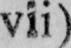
vii)
